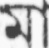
মা
